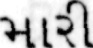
મારી
